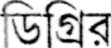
ডিগ্রির
